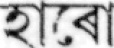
হাৰো
